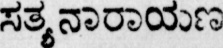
ಸತ್ಯನಾರಾಯಣ
